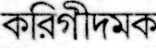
করিগীদমক
